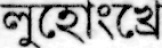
লুহোংখ্রে
